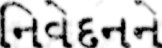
નિવેદનને
